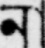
না
